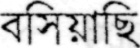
বসিয়াছি
